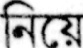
নিয়ে
